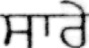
ਸਾਰੇ
